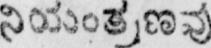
ನಿಯಂತ್ರಣವು
